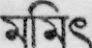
মমিৎ
